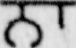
ਨਾ
